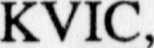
KVIC,
